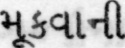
મૂકવાની
